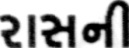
રાસની
